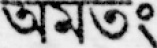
অমতং
